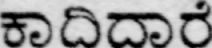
ಕಾದಿದಾರೆ
